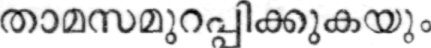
താമസമുറപ്പിക്കുകയും
